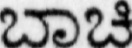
ಬಾಚಿ
